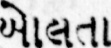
બોલતા
